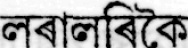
লৰালৰিকৈ
